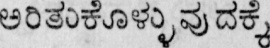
ಅರಿತುಕೊಳ್ಳುವುದಕ್ಕೆ
